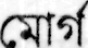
মোর্গ
